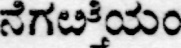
ನೆಗೞ್ತೆಯಂ
